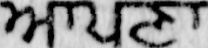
ਆਪਣਾ
